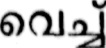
വെച്ച്
